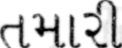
તમારી
